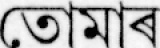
তোমাৰ
